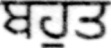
ਬਹੁਤ
